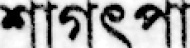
শাগৎপা
